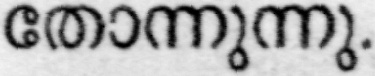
തോന്നുന്നു.
